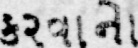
કરવાનો
